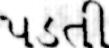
પડતી
